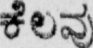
ಕೆಲವು
